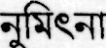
নুমিৎনা
